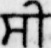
ਸੀ
